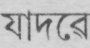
যাদৱে
